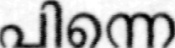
പിന്നെ
